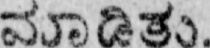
ಮಾಡಿತು.
